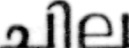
ചില
